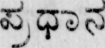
ಪ್ರಧಾನ
